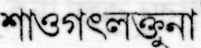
শাওগৎলক্তুনা
